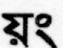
য়ং
